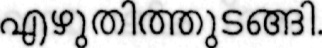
എഴുതിത്തുടങ്ങി.
